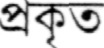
প্রকৃত
